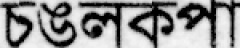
চঙলকপা
